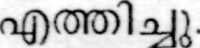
എത്തിച്ചു.
